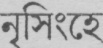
নৃসিংহে
